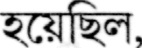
হয়েছিল,
